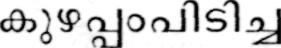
കുഴപ്പംപിടിച്ച
